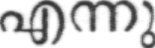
എന്നു
